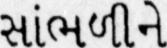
સાંભળીને
